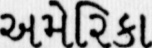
અમેરીકા
